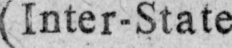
(Inter-State
